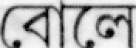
বোলে
